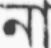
না
